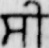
ਸੀ
